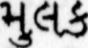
મુલક
